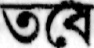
তবে
